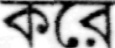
করে
